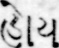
હોય
